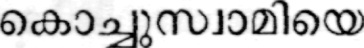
കൊച്ചുസ്വാമിയെ
